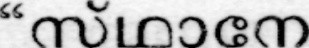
“സ്ഥാനേ
